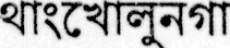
থাংখোলুনগা
